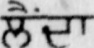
ਲੈਂਦਾ
